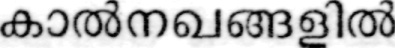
കാല്‍നഖങ്ങളില്‍
